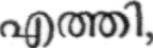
എത്തി,
